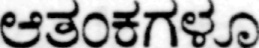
ಆತಂಕಗಳೂ
